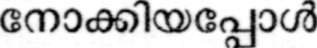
നോക്കിയപ്പോള്‍
